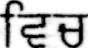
ਵਿਚ
